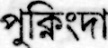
পুক্নিংদা
